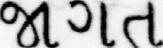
જાગત
